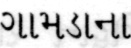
ગામડાના
